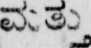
ಮತ್ತು
